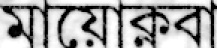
মায়োক্নবা
